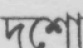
দশো
